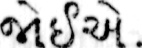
જોઈએ.
